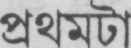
প্রথমটা
